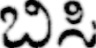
ಬಿಸಿ
